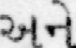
અને
